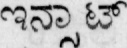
ಇನ್ಸಾಟ್
